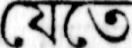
যেতে
